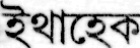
ইথাহেক
